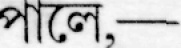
পালে,-
